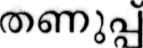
തണുപ്പ്
